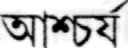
আশ্চর্য
